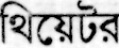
থিয়েটর
